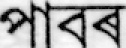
পাবৰ
